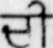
ਦੀ
